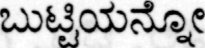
ಬುಟ್ಟಿಯನ್ನೋ
